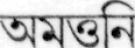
অমত্তনি
